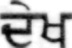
ਦੇਖ
